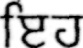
ਇਹ
